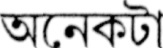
অনেকটা
